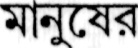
মানুষের
